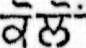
ਕੋਲੋਂ
